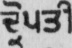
ਦ੍ਰੋਪਤੀ
